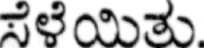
ಸೆಳೆಯಿತು.
